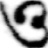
ও
